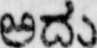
ಅದು
